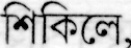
শিকিলে,
